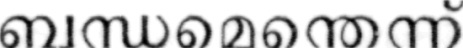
ബന്ധമെന്തെന്ന്
